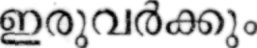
ഇരുവര്‍ക്കും
